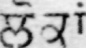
ਲੋਕਾਂ
